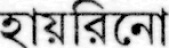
হায়রিনো
